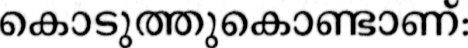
കൊടുത്തുകൊണ്ടാണ്:
